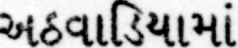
અઠવડિયામાં
